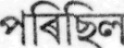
পৰিছিল
